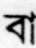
বা
